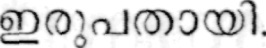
ഇരുപതായി.
